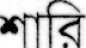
শারি
